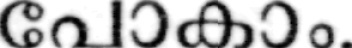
പോകാം.
